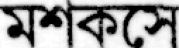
মশকসে
